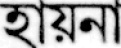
হায়না
